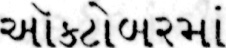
ઑક્ટોબરમાં
